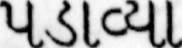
પડાવ્યા
